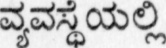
ವ್ಯವಸ್ಥೆಯಲ್ಲಿ
